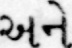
અને
